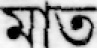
মাত
